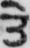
ਤੇ
